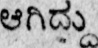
ಆಗಿದ್ದು
